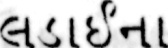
લડાઈના
